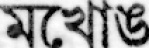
মখোঙ
